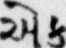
એક
